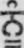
ਨੂੰ
